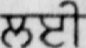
ਲਈ
